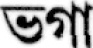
ভগা
